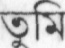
তুমি
